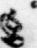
હું
